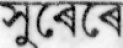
সুৰেৰে
